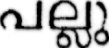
പല്ലു
